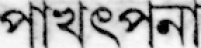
পাখৎপনা
